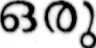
ഒരു
